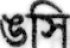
ঙসি
